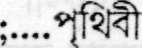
;....পৃথিবী
